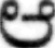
ಆ
